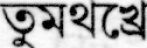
তুমথখ্রে
